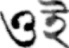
ওই
